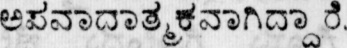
ಅಪವಾದಾತ್ಮಕವಾಗಿದ್ದಾರೆ.
